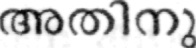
അതിനു
